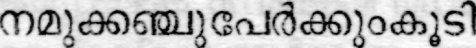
നമുക്കഞ്ചുപേര്‍ക്കുംകൂടി
